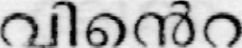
വിന്റെ
